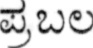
ಪ್ರಬಲ
